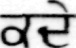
ਕਦੇ
